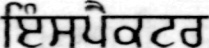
ਇੰਸਪੈਕਟਰ
